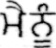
ਮੈਨੂੰ
